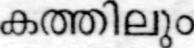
കത്തിലും
